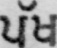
ਪੱਖ
